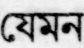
যেমন
